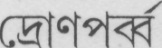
দ্ৰোণপৰ্ব্ব
